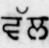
ਵੱਲ
